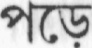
পড়ে
